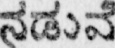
ನಡುವೆ
